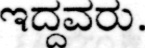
ಇದ್ದವರು.
